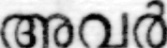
അവര്‍
